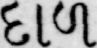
દાળ
